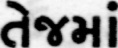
તેજમાં
